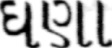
ઘણા
